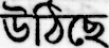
উঠিছে
